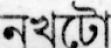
নখটো
